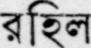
রহিল
